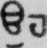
ਉਹ
